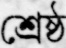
শ্রেষ্ঠ
